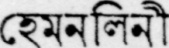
হেমনলিনী
